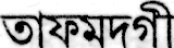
তাফমদগী
